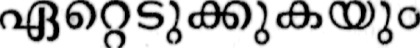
ഏറ്റെടുക്കുകയും
